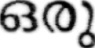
ഒരു
